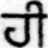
ਹੀ
